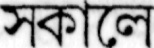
সকালে
